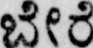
ಬೇರೆ
